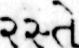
રસ્તે
